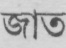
জাত
